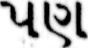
પણ
